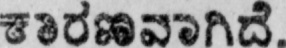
ಕಾರಣವಾಗಿದೆ.
